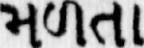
મળતા
